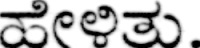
ಹೇಳಿತು.
